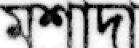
মশাদা
